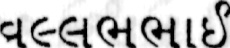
વલ્લભભાઈ
